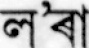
ল'ৰা
